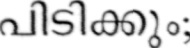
പിടിക്കും;
